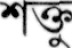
শক্তু
